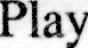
Play
